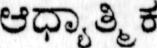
ಆಧ್ಯಾತ್ಮಿಕ
